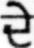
ਦੇ
